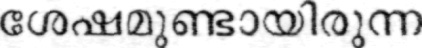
ശേഷമുണ്ടായിരുന്ന
